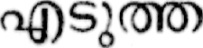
എടുത്ത
